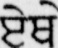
ਏਥੇ
